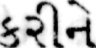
કરીને
